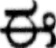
ಈ
